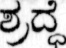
ಶ್ರದ್ಧೆ
